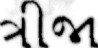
ત્રીજા
